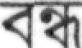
বন্ধ
